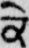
ਕੇ
